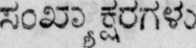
ಸಂಖಾಕ್ಷರಗಳು
